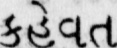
કહેવત
